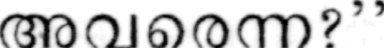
അവരെന്ന?"
